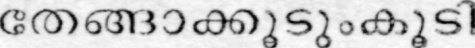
തേങ്ങാക്കൂടുംകൂടി
